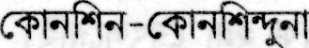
কোনশিন-কোনশিন্দুনা
